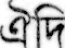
ঐদি
